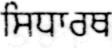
ਸਿਧਾਰਥ
